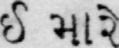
ઈમારે
